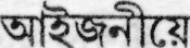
আইজনীয়ে
